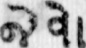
જેવો
